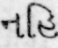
નહિ
